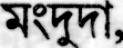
মংদুদা,
